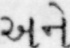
અને
